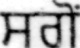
ਸਗੋਂ
